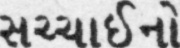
સચ્ચાઈનો
